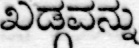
ಖಡ್ಗವನ್ನು
